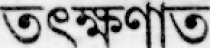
তৎক্ষণাত
